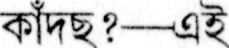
কাঁদছ?–এই
